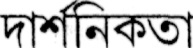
দার্শনিকতা
